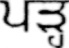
ਪੜ੍ਹ
